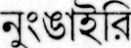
নুংঙাইরি
